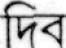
দিব
